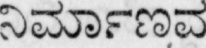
ನಿರ್ಮಾಣವ
